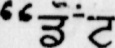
''ਡੋਂਟ
